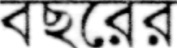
বছরের
